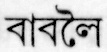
বাবলৈ
